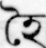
হৈ
